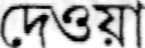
দেওয়া
